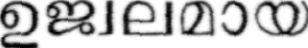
ഉജ്വലമായ
